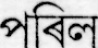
পৰিল
